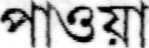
পাওয়া
